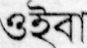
ওইবা
